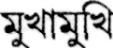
মুখামুখি
